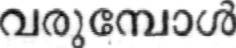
വരുമ്പോള്‍
